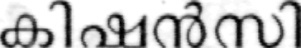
കിഷന്‍സി
